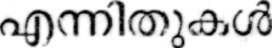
എന്നിതുകള്‍
